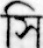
সি
